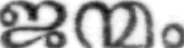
ജന്മം
